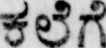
ಕಲೆಗೆ
